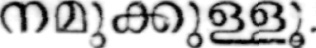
നമുക്കുള്ളൂ.
